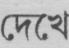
দেখে
